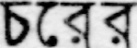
চরের
